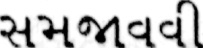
સમજાવવી
